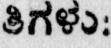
ತಿಗಳು:
